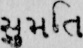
સુમતિ
